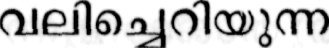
വലിച്ചെറിയുന്ന
